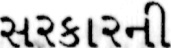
સરકારની
